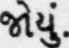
જોયું.
